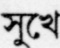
সুখে
